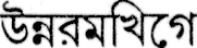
উন্নরমখিগে
